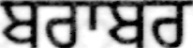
ਬਰਾਬਰ
